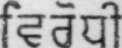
ਵਿਰੋਧੀ
